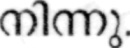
നിന്നു.
